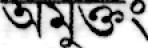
অমুক্তং
